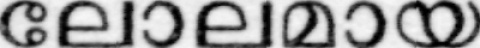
ലോലമായ
